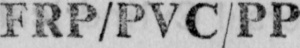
FRP/PVC/PP
